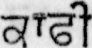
ਕਾਫੀ
